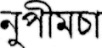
নুপীমচা
